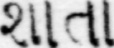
શાતા
